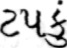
ટપકું
